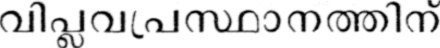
വിപ്ലവപ്രസ്ഥാനത്തിന്
